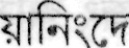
য়ানিংদে
